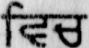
ਵਿਚ
